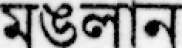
মঙলান
